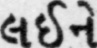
લઈને
